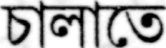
চালাতে
